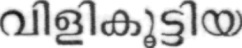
വിളികൂട്ടിയ
